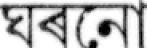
ঘৰনো
